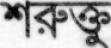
শরুক্তু
